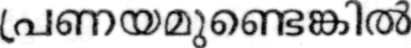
പ്രണയമുണ്ടെങ്കില്‍
